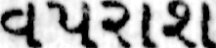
વપરાશ
